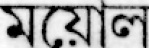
ময়োল
